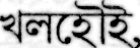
খলহৌই
